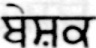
ਬੇਸ਼ਕ
